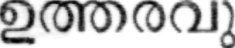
ഉത്തരവു
